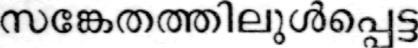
സങ്കേതത്തിലുള്‍പ്പെട്ട
